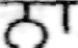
ਨਾ
